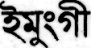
ইমুংগী
